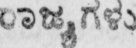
ರಾಜ್ಯಗಳು
